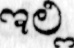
ಇಲ್ಲಿ
